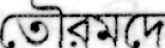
তৌরমদে
